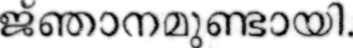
ജ്ഞാനമുണ്ടായി.
